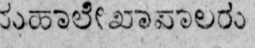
ಮಹಾಲೇಖಾಪಾಲರು
